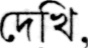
দেখি,
